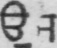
ਉਸ
